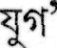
যুগ’
